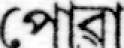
পোৱা
